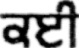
ਕਈ
